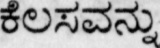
ಕೆಲಸವನ್ನು
